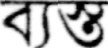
ব্যস্ত
